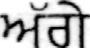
ਅੱਗੇ
